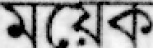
ময়েক
